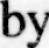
by
